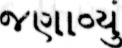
જણાવ્યું
